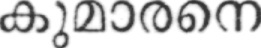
കുമാരനെ
